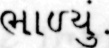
ભાળ્યું.
